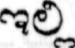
ಇಲ್ಲಿ
